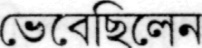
ভেবেছিলেন
